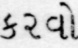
કરવો
